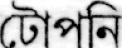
টোপনি
